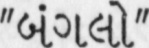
"બંગલો"
